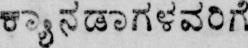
ಕ್ಯಾನಡಾಗಳವರಿಗೆ
